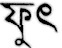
ফুৎ
